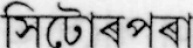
সিটোৰপৰা
